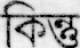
কিন্তু
